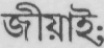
জীয়াই;
